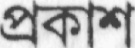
প্রকাশ
